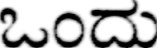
ಒಂದು
